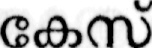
കേസ്
